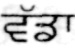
ਵੱਡਾ
